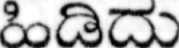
ಹಿಡಿದು
